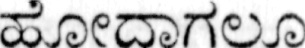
ಹೋದಾಗಲೂ
